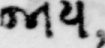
જાય,
